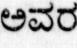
ಅವರ
